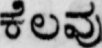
ಕೆಲವು
